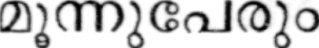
മൂന്നുപേരും
